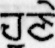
ਹੁਣੇ
